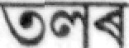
তলৰ
